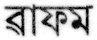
ৱাফম
